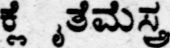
ಕ್ಲೈತೆಮೆಸ್ತ್ರ
